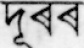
দূৰৰ
